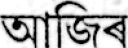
আজিৰ
